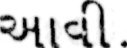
આવી.
